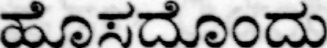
ಹೊಸದೊಂದು
